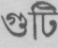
গুটি
